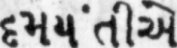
દમયંતીએ
